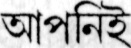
আপনিই
